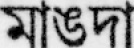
মাঙদা
